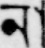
না
